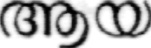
ആയ
